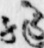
કહે
